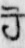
ਹੋ
